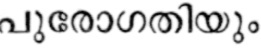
പുരോഗതിയും
